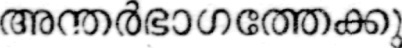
അന്തര്‍ഭാഗത്തേക്കു
